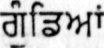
ਗੁੰਡਿਆਂ
